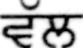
ਵੱਲ
